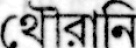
থৌরানি
